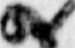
જ
